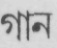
গান
